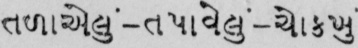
તળાએલું-તપાવેલું-ચોકખું
